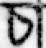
চা
